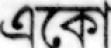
একো
